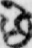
છે
